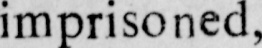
imprisoned,
